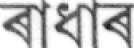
ৰাধাৰ
